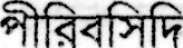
পীরিবসিদি
